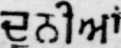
ਦੁਨੀਆਂ
